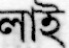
লাই
